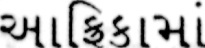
આફ્રિકામાં
